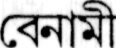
বেনামী
